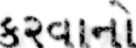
કરવાનો
